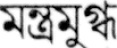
মন্ত্রমুগ্ধ
